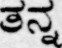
ತನ್ನ
